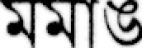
মমাঙ
